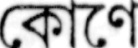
কোণে
